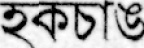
হকচাঙ
